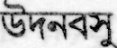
উদনবসু
